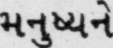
મનુષ્યને
